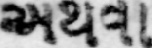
અથવા
